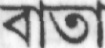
বাতা
